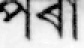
পৰা
